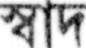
স্বাদ
